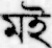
মই
